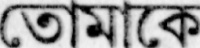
তোমাকে
